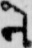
ને
